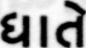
ધાતે
